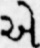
એ
